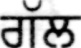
ਗੱਲ
